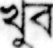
খুব
